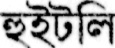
হুইটলি
